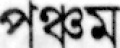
পঞ্চম
